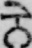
ਨੇ
